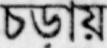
চড়ায়
